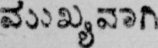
ಮುಖ್ಯವಾಗಿ
